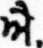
ਐ,
